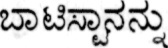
ಬಾಟಿಸ್ಪಾನನ್ನು
